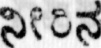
ನೀರಿನ
